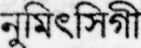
নুমিৎসিগী
